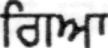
ਗਿਆ
